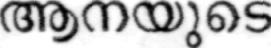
ആനയുടെ
